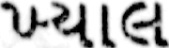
ખ્યાલ
